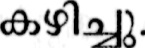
കഴിച്ചു.
